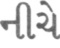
નીચે
